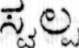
ಸ್ವಲ್ಪ
